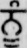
ਨੂੰ
